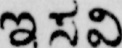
ಇಸವಿ
